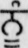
ਨੂੰ
